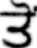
ਤੋਂ
